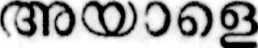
അയാളെ
